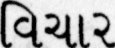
વિચાર
